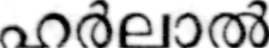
ഹര്‍ലാല്‍
